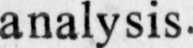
analysis.
